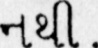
નથી.
